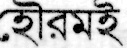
হৌরমই
